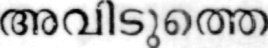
അവിടുത്തെ
